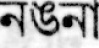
নঙনা
